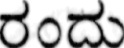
ರಂದು
